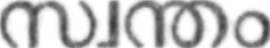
സ്വന്തം
